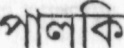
পালকি
